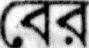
বের
